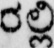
ರಲ್ಲಿ
